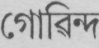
গোৱিন্দ
